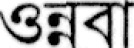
ওন্নবা
